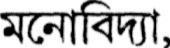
মনোবিদ্যা,
